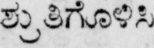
ಶ್ರುತಿಗೊಳಿಸಿ
